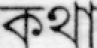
কথা
